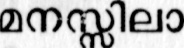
മനസ്സിലാ
